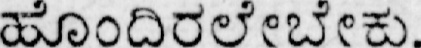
ಹೊಂದಿರಲೇಬೇಕು.
